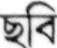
ছবি
